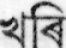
খৰি
